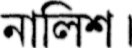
নালিশ।
